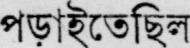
পড়াইতেছিল
